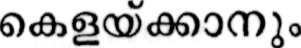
കെളയ്ക്കാനും
